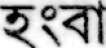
হংবা
